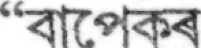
"বাপেকৰ
